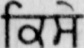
ਕਿਸੇ
